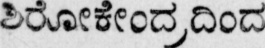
ಶಿರೋಕೇಂದ್ರದಿಂದ
